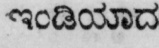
ಇಂಡಿಯಾದ
